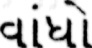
વાંધો
